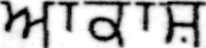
ਆਕਾਸ਼
